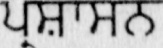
ਪ੍ਰਸ਼ਾਸਨ
